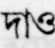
দাও
